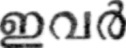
ഇവര്‍
